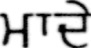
ਮਾਦੇ
